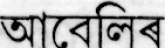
আবেলিৰ
